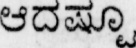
ಆದಷ್ಟೂ
